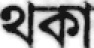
থকা
